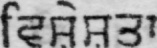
ਵਿਸ਼ੇਸ਼ਤਾ
